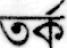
তর্ক
